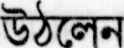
উঠলেন
